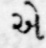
એ
